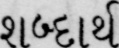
શબ્દાર્થ
